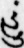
હું
